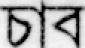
চাব
